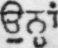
ਉਨ੍ਹਾਂ
